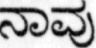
ನಾವು
